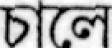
চালে
